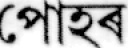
পোহৰ
